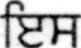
ਇਸ
